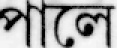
পালে
